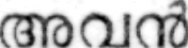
അവന്‍
